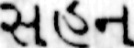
સહન
